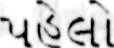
પહેલો
